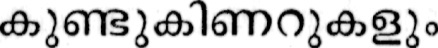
കുണ്ടുകിണറുകളും
